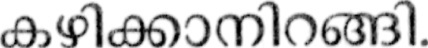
കഴിക്കാനിറങ്ങി.
